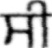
ਸੀ
